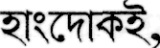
হাংদোকই,
